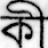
কী
